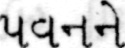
પવનને
